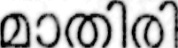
മാതിരി
